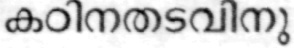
കഠിനതടവിനു
